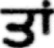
ਤਾਂ
